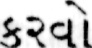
કરવો
